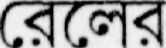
রেলের
